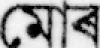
মোৰ
